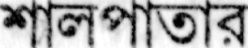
শালপাতার
